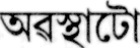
অৱস্থাটো
